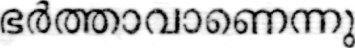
ഭര്‍ത്താവാണെന്നു
